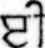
ਈ
